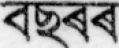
বছৰৰ
